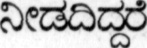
ನೀಡದಿದ್ದರೆ
